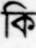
কি
